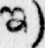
ಇ)
